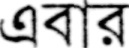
এবার
